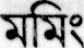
মমিং
